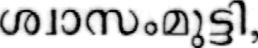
ശ്വാസംമുട്ടി,
